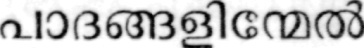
പാദങ്ങളിന്മേല്‍
